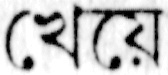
খেয়ে
